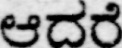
ಆದರೆ
